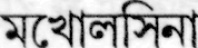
মখোলসিনা
